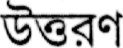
উত্তরণ
